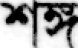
শঙ্গ
